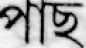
পাছ
